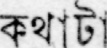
কথাটা
